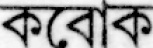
কবোক
